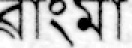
ৱাংমা
